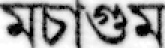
মচাগুম
